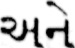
અને
